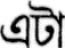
এটা
